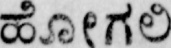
ಹೋಗಲಿ
